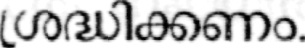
ശ്രദ്ധിക്കണം.
